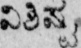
ವಿಶಿಷ್ಟ
